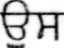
ਉਸ
